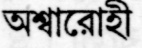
অশ্বারোহী
